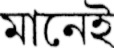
মানেই
